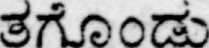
ತಗೊಂಡು
